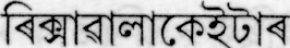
ৰিক্সাৱালাকেইটাৰ
